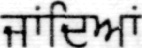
ਜਾਂਦਿਆਂ
